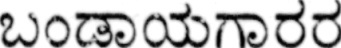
ಬಂಡಾಯಗಾರರ
